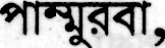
পাম্মুরবা,
